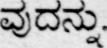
ವುದನ್ನು.
